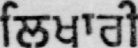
ਲਿਖਾਰੀ
